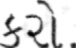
કરો.
